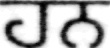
ਹਨ
